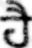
ਹੈ
